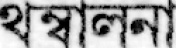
থম্বালনা
